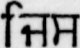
ਜਿਸ
